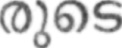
രുടെ
